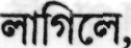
লাগিলে,
